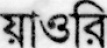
য়াওরি
